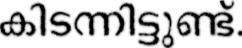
കിടന്നിട്ടുണ്ട്.
